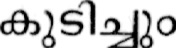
കുടിച്ചും
